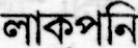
লাকপনি
